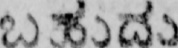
ಬಹುದು
